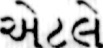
એટલે
